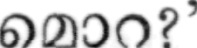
മൊറ?'
